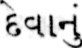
દેવાનું
